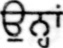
ਉਨ੍ਹਾਂ
